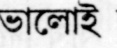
ভালোই
